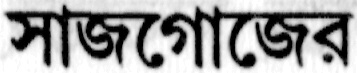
সাজগোজের
